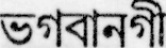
ভগবানগী
